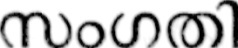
സംഗതി
